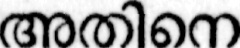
അതിനെ
